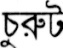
চুরুট
